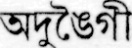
অদুঙৈগী
